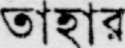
তাহার
